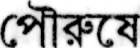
পৌরুষে
